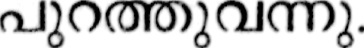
പുറത്തുവന്നു.
